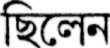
ছিলেন
